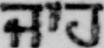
ਜਾਹ
